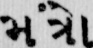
મંત્રો
